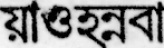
য়াওহন্নবা
